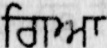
ਗਿਆ
